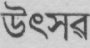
উৎসৱ
